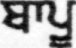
ਬਾਪੂ
